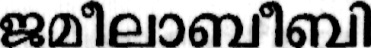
ജമീലാബീബി
